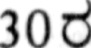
30ರ
